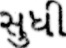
સુધી
